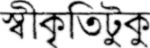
স্বীকৃতিটুকু
